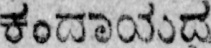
ಕಂದಾಯದ
